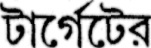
টার্গেটের
